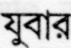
যুবার
